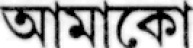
আমাকো
